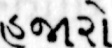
હજારો
